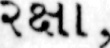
રક્ષા,
